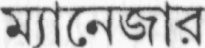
ম্যানেজার
